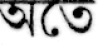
অতৈ
